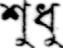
শুধু
